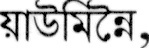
য়াউমিন্নৈ,
